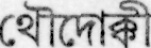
থৌদোক্কী
